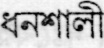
ধনশালী
